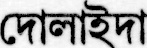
দোলাইদা
